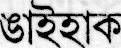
ঙাইহাক
